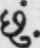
છું.
